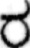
ರ
